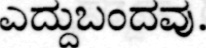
ಎದ್ದುಬಂದವು.
